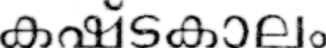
കഷ്ടകാലം
